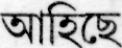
আহিছে
